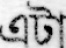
এটা
